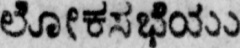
ಲೋಕಸಭೆಯು
